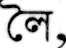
লৈ,
